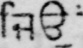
ਜਿਉਂ
